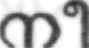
നീ
